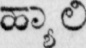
ಹ್ಯಾಲಿ
